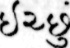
ઈચ્છું
